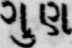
ગુણ
